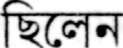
ছিলেন
